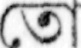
তো
